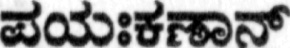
ಪಯಃಕಣಾನ್
